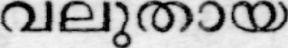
വലുതായ
